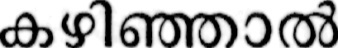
കഴിഞ്ഞാല്‍
